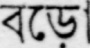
বড়ো
